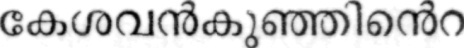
കേശവന്‍കുഞ്ഞിന്റെ
